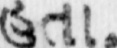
હતા.
